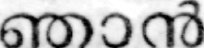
ഞാന്‍
